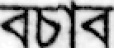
বচাব
